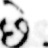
છે.
